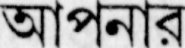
আপনার
